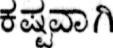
ಕಷ್ಟವಾಗಿ
